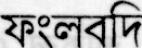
ফংলবদি
